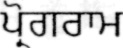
ਪ੍ਰੋਗਰਾਮ
